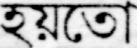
হয়তো
